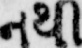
નથી
